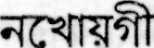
নখোয়গী
